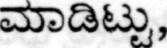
ಮಾಡಿಟ್ಟು,
